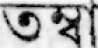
তম্বা
